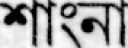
শাংনা
